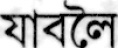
যাবলৈ
